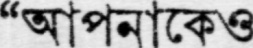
‘‘আপনাকেও
